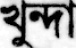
খুন্দা
